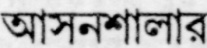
আসনশালার
